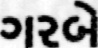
ગરબે
